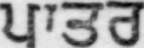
ਪਾਤਰ
